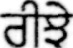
ਰੀਝੇ
